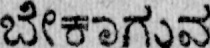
ಬೇಕಾಗುವ
